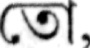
তো,
